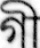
গী
